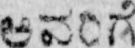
ಅವರಿಗೆ
